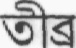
তীব্র
